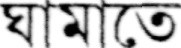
ঘামাতে
